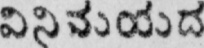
ವಿನಿಮಯದ
